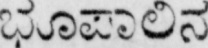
ಭೂಪಾಲಿನ
